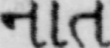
નાત
